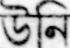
উনি
